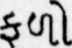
ફળો
